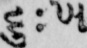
દુઃખ
